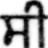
ਸੀ
